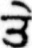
ਤੇ
